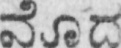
ಮೊದ
